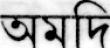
অমদি
